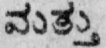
ಮತ್ತು
